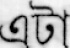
এটা
